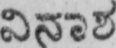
ವಿನಾಶ
